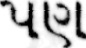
પણ
